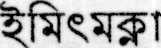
ইমিৎমক্না
